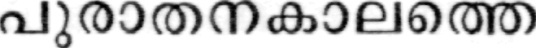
പുരാതനകാലത്തെ
